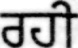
ਰਹੀ
